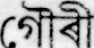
গৌৰী
